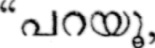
"പറയൂ,
